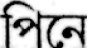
পিনে
